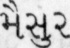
મૈસુર
